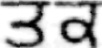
ਤਕ
